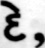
દે,
